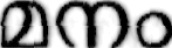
മനം
